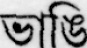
ভাঙি
